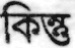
কিন্তু
